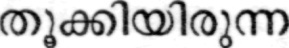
തൂക്കിയിരുന്ന
